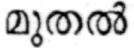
മുതല്‍
